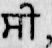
ਸੀ,
